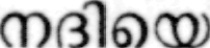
നദിയെ
